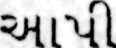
આપી
